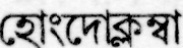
হোংদোক্লম্বা
